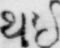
થઈ
